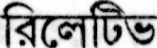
রিলেটিভ
